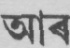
আৰ
